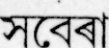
সবেৰা
